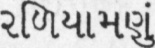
રળિયામણું
